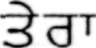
ਤੇਰਾ
